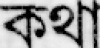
কথা
